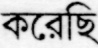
করেছি
